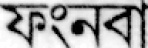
ফংনবা
